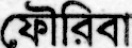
ফৌরিবা
